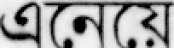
এনেয়ে
